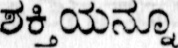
ಶಕ್ತಿಯನ್ನೂ
